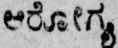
ಆರೋಗ್ಯ
